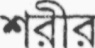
শরীর
